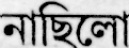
নাছিলো
